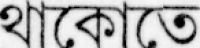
থাকোতে
